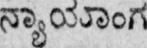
ನ್ಯಾಯಾಂಗ
